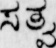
ಸತ್ವ
